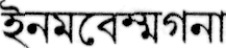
ইনমবেম্মগনা
